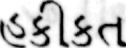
હકીકત
